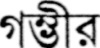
গম্ভীর
